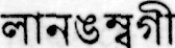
লানঙম্বগী
